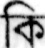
কি
